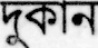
দুকান
